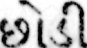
છોડી
